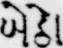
બેઠો
